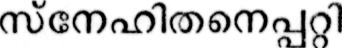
സ്നേഹിതനെപ്പറ്റി
